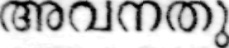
അവനതു
